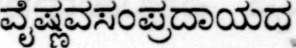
ವೈಷ್ಣವಸಂಪ್ರದಾಯದ
